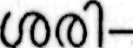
ശരി-
